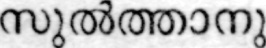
സുല്‍ത്താനു
